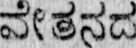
ವೇತನದ
